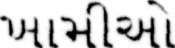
ખામીઓ
